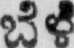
ಬೆಳೆ
